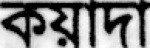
কয়াদা
